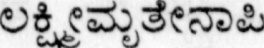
ಲಕ್ಷ್ಮೀಮೃತೇನಾಪಿ
